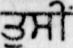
ਤੁਸੀਂ
